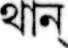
থান্
